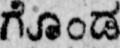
ಗೊಂಡ
